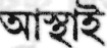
আস্থাই
